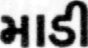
માડી
